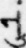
નું
